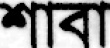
শাবা
